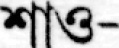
শাও-
